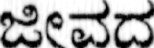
ಜೀವದ
